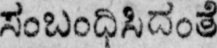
ಸಂಬಂಧಿಸಿದಂತೆ
